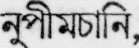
নুপীমচানি,
